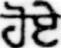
ਹੋਏ
